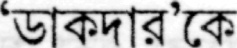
‘ডাকদার’কে
